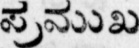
ಪ್ರಮುಖ
